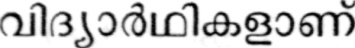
വിദ്യാര്‍ഥികളാണ്
